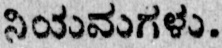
ನಿಯಮಗಳು.
